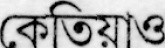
কেতিয়াও
